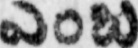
ಎಂಬ
